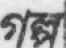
গল্প
